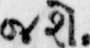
જશે.
